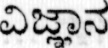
ವಿಜ್ಞಾನ
